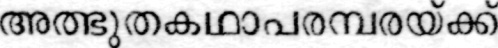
അത്ഭുതകഥാപരമ്പരയ്ക്ക്
